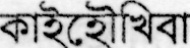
কাইহৌখিবা
